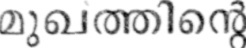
മുഖത്തിന്റെ
